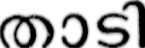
താടി
